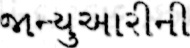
જાન્યુઆરીની
